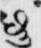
છું
